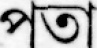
পতা
